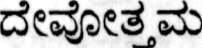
ದೇವೋತ್ತಮ
